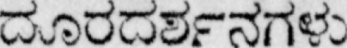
ದೂರದರ್ಶನಗಳು
